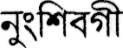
নুংশিবগী
